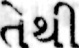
તેથી
